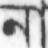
না
